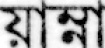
য়াম্না
